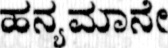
ಹನ್ಯಮಾನೇ
